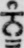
ਨੂੰ
